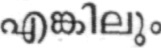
എങ്കിലും
